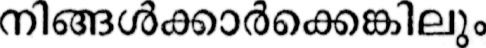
നിങ്ങള്‍ക്കാര്‍ക്കെങ്കിലും
